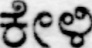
ಕೇಳಿ
